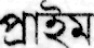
প্রাইম
